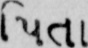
પિતા
